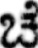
ಚೆ
